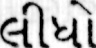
લીધો
